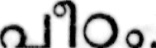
പീഠം.
